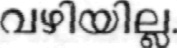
വഴിയില്ല.
